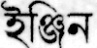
ইঞ্জিন
